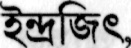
ইন্দ্রজিৎ,
